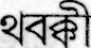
থবক্কী
